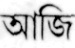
আজি
